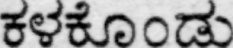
ಕಳಕೊಂಡು
